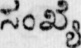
ಸಂಖ್ಯೆ
